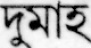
দুমাহ
